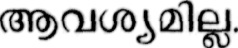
ആവശ്യമില്ല.
